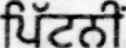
ਪਿੱਟਨੀ
